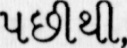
પછીથી,
